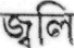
জ্বলি
